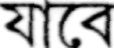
যাবে
